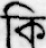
কি
